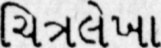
ચિત્રલેખા
